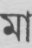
মা
